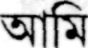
আমি
